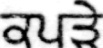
ਕਪੜੇ
